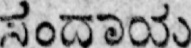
ಸಂದಾಯ
